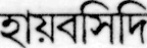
হায়বসিদি
